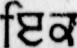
ਇਕ
